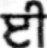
ਈ
